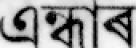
এন্ধাৰ
